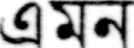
এমন
